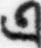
এ
